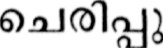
ചെരിപ്പു
